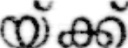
യ്ക്ക്
